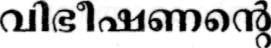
വിഭീഷണന്റെ
